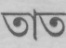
তাত
